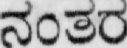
ನಂತರ
